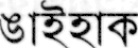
ঙাইহাক
